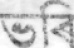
ভৰি
